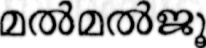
മല്‍മല്‍ജൂ
